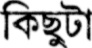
কিছুটা
